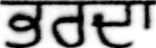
ਭਰਦਾ
